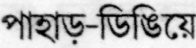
পাহাড়-ডিঙিয়ে
